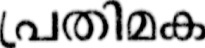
പ്രതിമക
